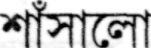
শাঁসালো
